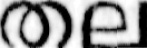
തല
